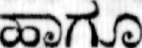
ಹಾಗೂ
